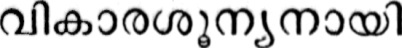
വികാരശൂന്യനായി
